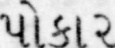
પોકાર
